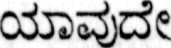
ಯಾವುದೇ
